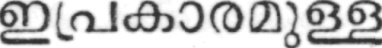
ഇപ്രകാരമുള്ള
